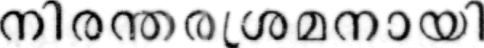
നിരന്തരശ്രമനായി
